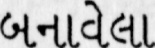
બનાવેલા
